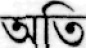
অতি
